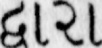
દ્વારા
